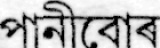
পানীবোৰ
